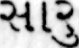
સારુ
